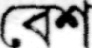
বেশ
